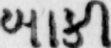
બાકી
